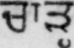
ਚਾੜ੍ਹ
